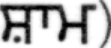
ਸ਼ਾਮ)
